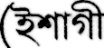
(ইশাগী
